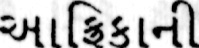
આફ્રિકાની
